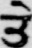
ਤੇ
